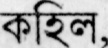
কহিল,
